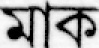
মাক
